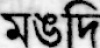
মঙদি
